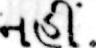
નહીં.
